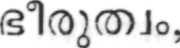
ഭീരുത്വം,
